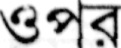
ওপর
